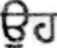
ਉਹ
